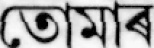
তোমাৰ
